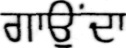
ਗਾਉਂਦਾ
